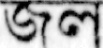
জল
